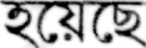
হয়েছে
